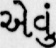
એવું
